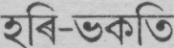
হৰি-ভকতি
